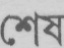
শেষ
